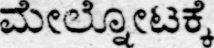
ಮೇಲ್ನೋಟಕ್ಕೆ
